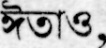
ঈতাও,
